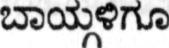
ಬಾಯ್ಗಳಿಗೂ
